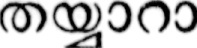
തയ്യാറാ
